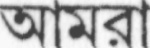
আমরা
